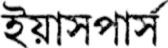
ইয়াসপার্স
